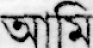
আমি
